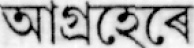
আগ্রহেৰে
